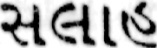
સલાહ
